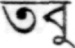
তবু
